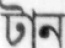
টান
